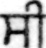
ਸੀ
